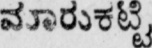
ಮಾರುಕಟ್ಟೆ
